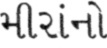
મીરાંનો
